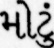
મોટું
